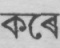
কৰে
